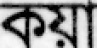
কয়া
